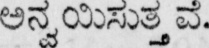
ಅನ್ವಯಿಸುತ್ತವೆ.
